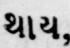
થાય,
